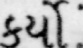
કર્યો.
